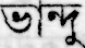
ভান্দু
